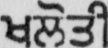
ਖਲੋਤੀ
